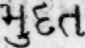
મુદત
